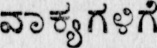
ವಾಕ್ಯಗಳಿಗೆ
